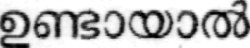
ഉണ്ടായാല്‍
